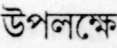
উপলক্ষে
